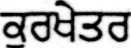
ਕੁਰਖੇਤਰ
